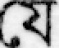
যে
